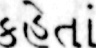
કહેતાં
